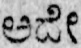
ಅದೇ
